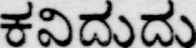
ಕವಿದುದು
